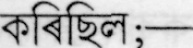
কৰিছিল;-
